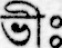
ভীঃ
